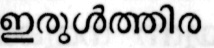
ഇരുള്‍ത്തിര
